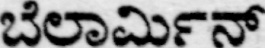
ಬೆಲಾರ್ಮಿನ್
